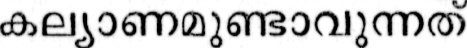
കല്യാണമുണ്ടാവുന്നത്
